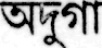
অদুগা
